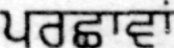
ਪਰਛਾਵਾਂ
